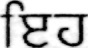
ਇਹ
